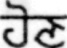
ਹੋਣ
